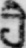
ਹੈ
